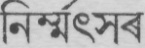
নিৰ্ম্মৎসৰ
